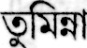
তুমিন্না
